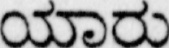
ಯಾರು
